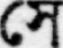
সে
